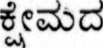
ಕ್ಷೇಮದ
